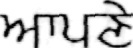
ਆਪਣੇ
